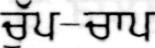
ਚੁੱਪ-ਚਾਪ
